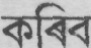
কৰিব
